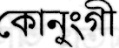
কোনুংগী
